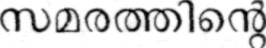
സമരത്തിന്റെ
